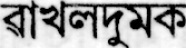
ৱাখলদুমক
